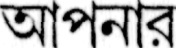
আপনার
